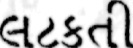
લટકતી
